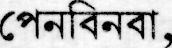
পেনবিনবা,
